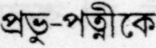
প্রভু-পত্নীকে
